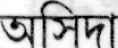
অসিদা
